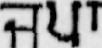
ਜਪਾ
